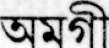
অমগী
